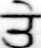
ਤੇ
